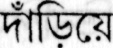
দাঁড়িয়ে
